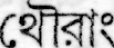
থৌরাং
